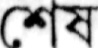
শেষ
